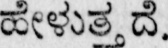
ಹೇಳುತ್ತದೆ.
